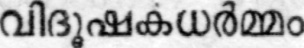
വിദൂഷകധര്‍മ്മം
